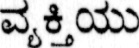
ವ್ಯಕ್ತಿಯು
